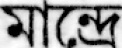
মান্দ্রে
